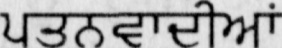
ਪਤਨਵਾਦੀਆਂ
